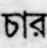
চার
